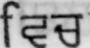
ਵਿਚ
